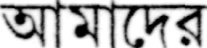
আমাদের
